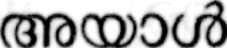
അയാള്‍
